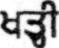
ਖੜ੍ਹੀ
